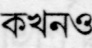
কখনও
